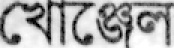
খোঞ্জেল
